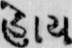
હોય
